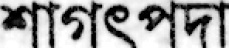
শাগৎপদা
